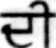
ਦੀ
